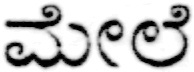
ಮೇಲೆ
